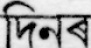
দিনৰ
